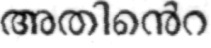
അതിന്റെ
